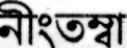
নীংতম্বা
